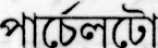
পার্চেলটো
